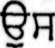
ਉਸ
